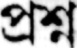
প্রশ্ন
